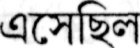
এসেছিল
